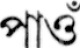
পাওঁ
